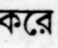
করে
